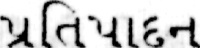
પ્રતિપાદન
